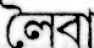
লৈবা
